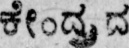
ಕೇಂದ್ರದ
